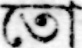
তো
